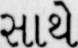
સાથે
